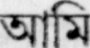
আমি
